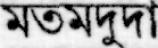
মতমদুদা
